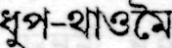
ধুপ-থাউমৈ
